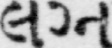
લગ્ન
